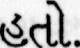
હતો.
